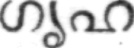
ഗൃഹ
